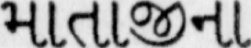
માતાજીના
